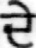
ਦੇ
